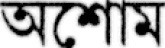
অশোম
